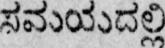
ಸಮಯದಲ್ಲಿ
